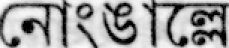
নোংঙাল্লে
